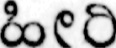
ಹೀರಿ
